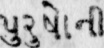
પુરુષોની
